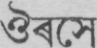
ঔৰসে
